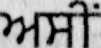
ਅਸੀਂ
